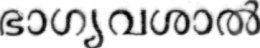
ഭാഗ്യവശാല്‍
